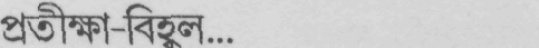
প্ৰতীক্ষা-বিহ্বল...
